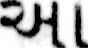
આ
